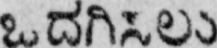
ಒದಗಿಸಲು
